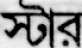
স্টার
